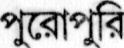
পুরোপুরি
